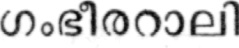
ഗംഭീരറാലി
